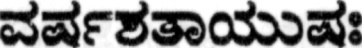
ವರ್ಷಶತಾಯುಷಃ
